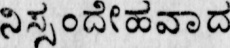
ನಿಸ್ಸಂದೇಹವಾದ
